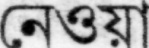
নেওয়া
